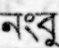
নংবু
